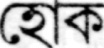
হোক
